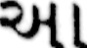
આ
